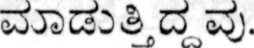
ಮಾಡುತ್ತಿದ್ದವು.
